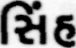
સિંહ
